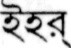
ইহর্
